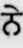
ਨੇ
